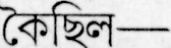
কৈছিল-
